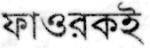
ফাওরকই
